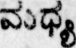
ಮಧ್ಯ
